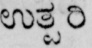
ಉತ್ಪರಿ
